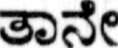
ತಾನೇ
